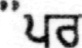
''ਪਰ
